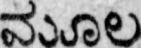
ಮೂಲ
